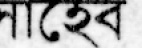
সাহেব
